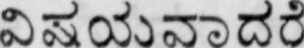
ವಿಷಯವಾದರೆ
